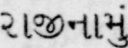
રાજીનામું
